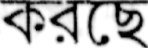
করছে
